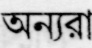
অন্যরা
